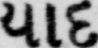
યાદ
